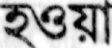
হওয়া
